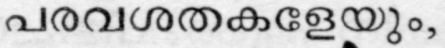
പരവശതകളേയും,
